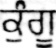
ਕੁੰਗੂ
